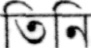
তিনি
